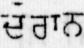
ਦੋਰਾਨ
